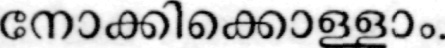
നോക്കിക്കൊള്ളാം.
